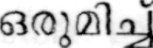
ഒരുമിച്ച്
